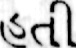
હતી
